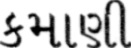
કમાણી
